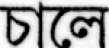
চালে
